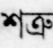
শত্রু
